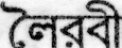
লৈরবী
